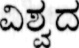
ವಿಶ್ವದ
